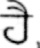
ਹੈ,
